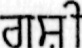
ਗਸ਼ੀ
